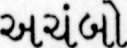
અચંબો
